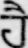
ਹੈ
